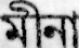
মীনা
